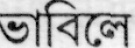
ভাবিলে
